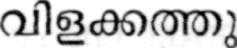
വിളക്കത്തു
